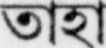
তাহা
